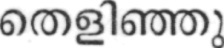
തെളിഞ്ഞു
